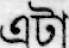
এটা
